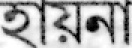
হায়না
